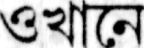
ওখানে
